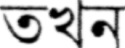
তখন
